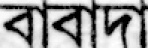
বাবাদা
